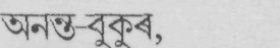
অনন্ত-বুকুৰ,
